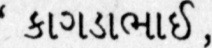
'કાગડાભાઈ,
